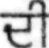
ਦੀ
